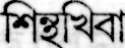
শিন্থখিবা
